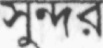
সুন্দর
